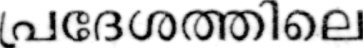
പ്രദേശത്തിലെ
